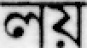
লয়
